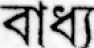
বাধ্য
